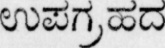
ಉಪಗ್ರಹದ
